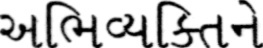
અભિવ્યક્તિને
